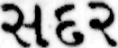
સદર
